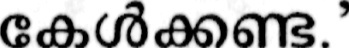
കേള്‍ക്കണ്ട.’
